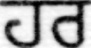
ਹਰ
